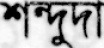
শন্দুদা
